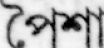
পৈশা
